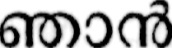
ഞാന്‍
